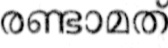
രണ്ടാമത്
